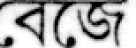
বেজে
